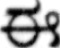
ಈ
